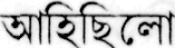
আহিছিলো
